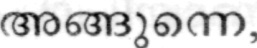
അങ്ങുന്നെ,
